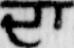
ਦਾ
